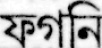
ফগনি
